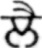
ਲੈ
